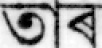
তাৰ
